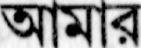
আমার
